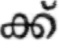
ക്ക്
